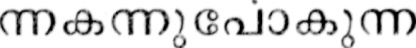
ന്നകന്നുപോകുന്ന
